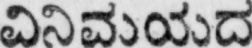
ವಿನಿಮಯದ
